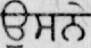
ਉਸਨੇ
